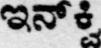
ಇನ್‌ಕ್ವಿ
